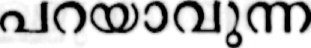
പറയാവുന്ന
